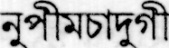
নুপীমচাদুগী
